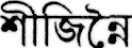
শীজিন্নৈ
